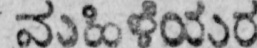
ಮಹಿಳೆಯರ
